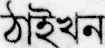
ঠাইখন
